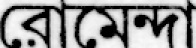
রোমেন্দা
